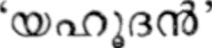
‘യഹൂദന്‍'
